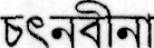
চৎনবীনা
